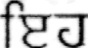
ਇਹ
